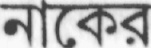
নাকের
